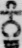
ਨੂੰ
